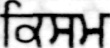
ਕਿਸਮ
